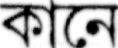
কানে
